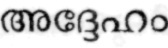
അദ്ദേഹം
